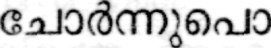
ചോര്‍ന്നുപൊ
